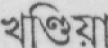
খণ্ডিয়া
